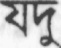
যদু
